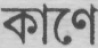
কাণে
